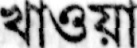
খাওয়া
